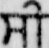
ਸੀ
